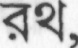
রথ,
